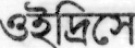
ওইদ্রসে
